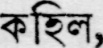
কহিল,
